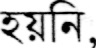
হয়নি,
